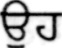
ਉਹ
